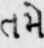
તમે
